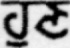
ਹੁਣ
